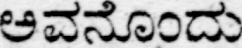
ಅವನೊಂದು
